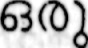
ഒരു
